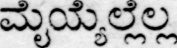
ಮೈಯ್ಯೆಲ್ಲೆಲ್ಲ
